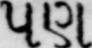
પણ
